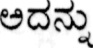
ಅದನ್ನು
